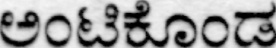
ಅಂಟಿಕೊಂಡ
